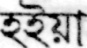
হইয়া
